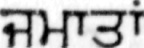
ਜਮਾਤਾਂ
